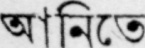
আনিতে
